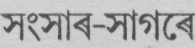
সংসাৰ-সাগৰে
